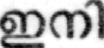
ഇനി
